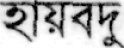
হায়বদু
